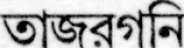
তাজরগনি
